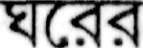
ঘরের
